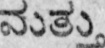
ಮತ್ತು
